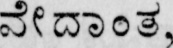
ವೇದಾಂತ,
